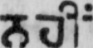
ਨਹੀਂ
